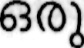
ഒരു
